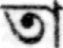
তা
